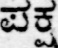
ಪಕ್ಷ
